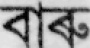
বাৰু
